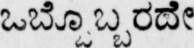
ಒಬ್ಬೊಬ್ಬರದೇ
